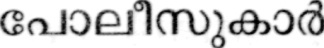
പോലീസുകാര്‍
